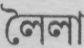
লৈলা
